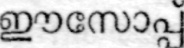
ഈസോപ്പ്
